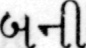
બની
